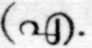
(എ.
